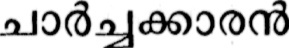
ചാര്‍ച്ചക്കാരന്‍
